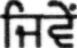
ਜਿਵੇਂ
